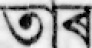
তাৰ
